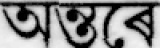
অন্তৰে
